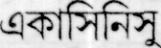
একাসিনিসু
